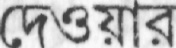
দেওয়ার
